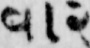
વાર
